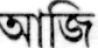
আজি
